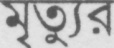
মৃত্যুর
